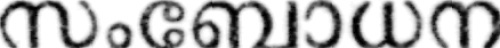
സംബോധന
